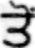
ਤੋਂ
